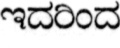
ಇದರಿಂದ
